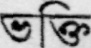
ভক্তি
